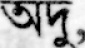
অদু,
